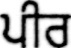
ਪੀਰ
